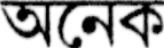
অনেক
